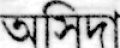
অসিদা
